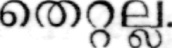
തെറ്റല്ല.
